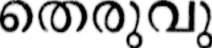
തെരുവു
